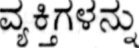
ವ್ಯಕ್ತಿಗಳನ್ನು
